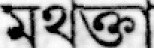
মথক্তা
